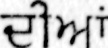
ਦੀਆਂ
